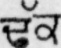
ਢੱਕ
